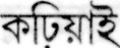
কঢ়িয়াই
